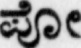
ಪೋ
